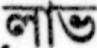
লাভ
